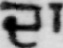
ਦਾ
